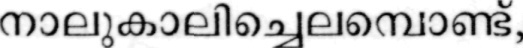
നാലുകാലിച്ചെലമ്പൊണ്ട്,
